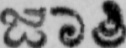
ಜಾತಿ
